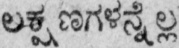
ಲಕ್ಷಣಗಳನ್ನೆಲ್ಲ
